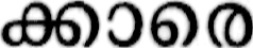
ക്കാരെ
